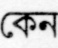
কেন
